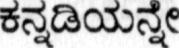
ಕನ್ನಡಿಯನ್ನೇ
